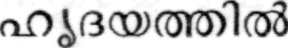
ഹൃദയത്തില്‍
